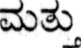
ಮತ್ತು
